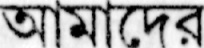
আমাদের
